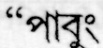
“পাবুং
